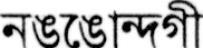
নঙঙোন্দগী
